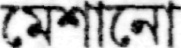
মেশানো
